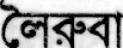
লৈরুবা
